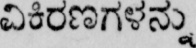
ವಿಕಿರಣಗಳನ್ನು
